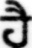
ਹੈ
